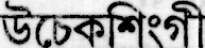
উচেকশিংগী
